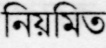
নিয়মিত
